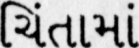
ચિંતામાં
